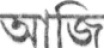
আজি
